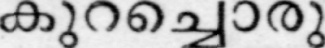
കുറച്ചൊരു
